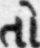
તો
